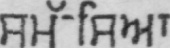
ਸਮੱਸਿਆ
